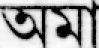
অমা
